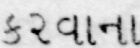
કરવાના
